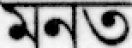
মনত
